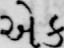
એક
